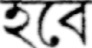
হবে
